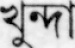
খুন্দা
